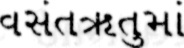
વસંતૠતુમાં
